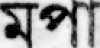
মপা
